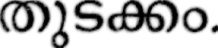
തുടക്കം.
